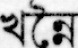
খন্নৈ
